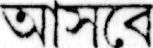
আসবে
